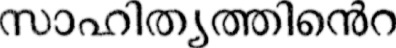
സാഹിത്യത്തിന്റെ
